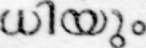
ധിയും
